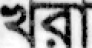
খরা
